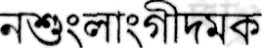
নশুংলাংগীদমক
